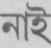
নাই
